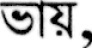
ভায়,
